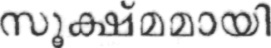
സൂക്ഷ്മമായി
